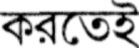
করতেই
